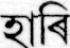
হাৰি
